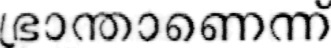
ഭ്രാന്താണെന്ന്
